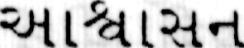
આશ્વાસન
